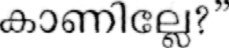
കാണില്ലേ?"
